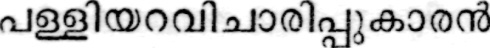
പള്ളിയറവിചാരിപ്പുകാരന്‍
